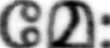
മേ:
